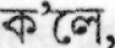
ক'লে,
